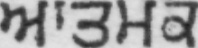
ਆਤਮਕ
